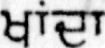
ਖਾਂਦਾ
